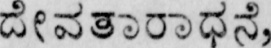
ದೇವತಾರಾಧನೆ,
